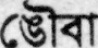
ঙৌবা
